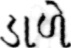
ડાળે
